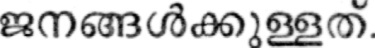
ജനങ്ങള്‍ക്കുള്ളത്.
